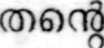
തന്റെ
